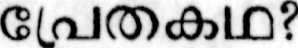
പ്രേതകഥ?
